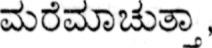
ಮರೆಮಾಚುತ್ತಾ,
